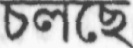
চলছে
